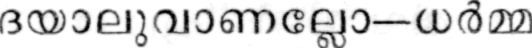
ദയാലുവാണല്ലോ-ധര്‍മ്മ
